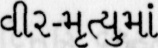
વીર-મૃત્યુમાં
